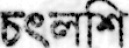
চৎলশি
